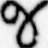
જ
